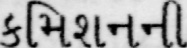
કમિશનની
